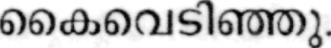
കൈവെടിഞ്ഞു.
